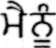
ਮੈਨੂੰ
